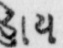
હોય
